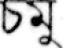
চমু
